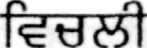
ਵਿਚਲੀ
